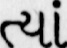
ત્યાં
